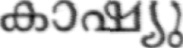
കാഷ്യു
